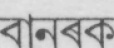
বানৰক
